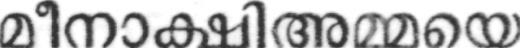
മീനാക്ഷിഅമ്മയെ
